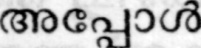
അപ്പോള്‍
